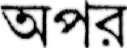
অপর
